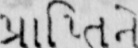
પ્રાપ્તિને
